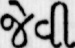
જેવી
